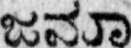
ಜಮಾ
